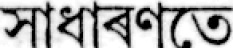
সাধাৰণতে
